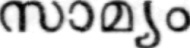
സാമ്യം
